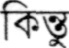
কিন্তু
